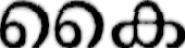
കൈ
